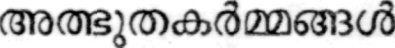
അത്ഭുതകര്‍മ്മങ്ങള്‍
